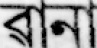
ৱানা
